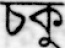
চকু
